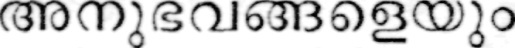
അനുഭവങ്ങളെയും
